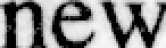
new
